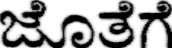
ಜೊತೆಗೆ
